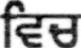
ਵਿਚ
